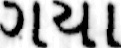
ગયા
